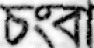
চংবা
